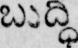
ಬುದ್ಧಿ
